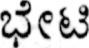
ಭೇಟಿ
